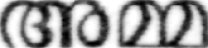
അമ്മ
